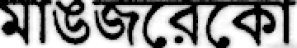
মাঙজরেকো
